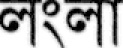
লংলা
